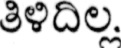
ತಿಳಿದಿಲ್ಲ.
